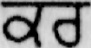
ਕਰ
